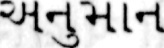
અનુમાન
